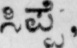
ಸಿಪ್ಪೆ,
